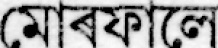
মোৰফালে
